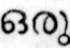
ഒരു
